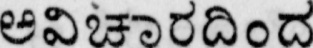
ಅವಿಚಾರದಿಂದ
